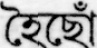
হৈছোঁ
